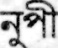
নুপী
